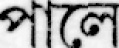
পালে
